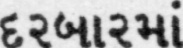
દરબારમાં
